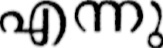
എന്നു
